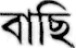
বাছি
